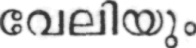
വേലിയും
